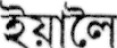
ইয়ালৈ
